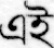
এই
